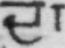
ਦਾ
